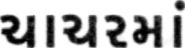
ચાચરમાં
